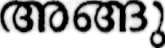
അങ്ങു
